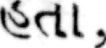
હતા,
